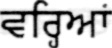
ਵਰ੍ਹਿਆਂ
